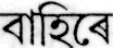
বাহিৰে
